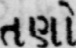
તણો
